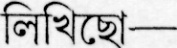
লিখিছো-
